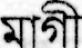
মাগী
